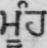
ਮੂੰਹ
